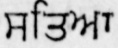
ਸਤਿਆ
